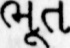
ભૂત
